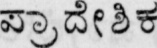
ಪ್ರಾದೇಶಿಕ
